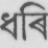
ধৰি
